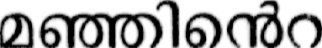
മഞ്ഞിന്റെ
